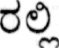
ರಲ್ಲಿ
